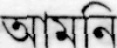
আমনি
